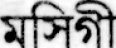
মসিগী
